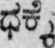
ಧಕ್ಕೆ
